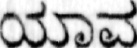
ಯಾವ
